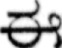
ಈ
